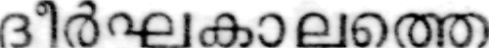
ദീര്‍ഘകാലത്തെ
